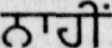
ਨਾਹੀਂ
